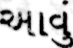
આવું
